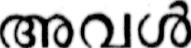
അവള്‍
